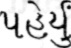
પહેર્યું
